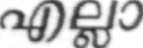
എല്ലാ
